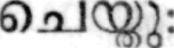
ചെയ്തു:
